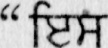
''ਇਸ
